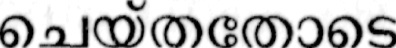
ചെയ്തതോടെ
